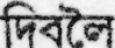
দিবলৈ
